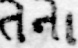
તેનો
